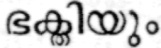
ഭക്തിയും
